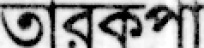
তারকপা
